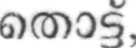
തൊട്ട്,
